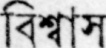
বিশ্বাস
